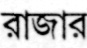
রাজার
